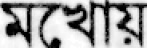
মখোয়
